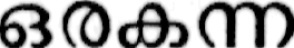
ഒരകന്ന
